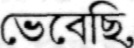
ভেবেছি,
